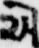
એ
